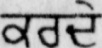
ਕਰਦੇ
